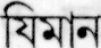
যিমান
